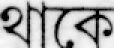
থাকে
